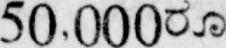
50,000ರೂ
